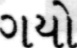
ગયો
